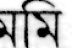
মমি
